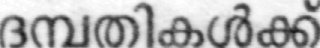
ദമ്പതികള്‍ക്ക്
